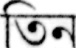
তিন
